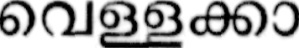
വെള്ളക്കാ
